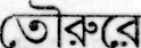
তৌরুরে
